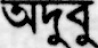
অদুবু
